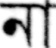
না
